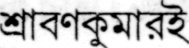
শ্রাবণকুমারই
